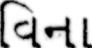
વિના
